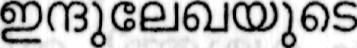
ഇന്ദുലേഖയുടെ
